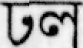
ঢল
